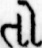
તો
